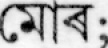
মোৰ;
